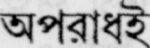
অপরাধই
